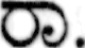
ರಾ.
